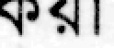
কয়া
